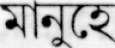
মানুহে
